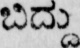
ಬಿದ್ದು
